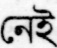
নেই
